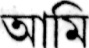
আমি
